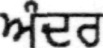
ਅੰਦਰ
